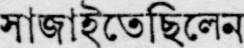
সাজাইতেছিলেন
